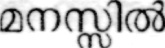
മനസ്സില്‍
